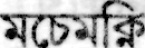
মচেমক্নি
